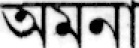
অমনা
